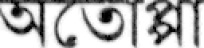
অতোপ্পা
